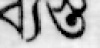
ব্যস্ত
